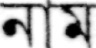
নাম
